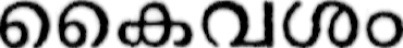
കൈവശം
